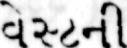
વેસ્ટની
